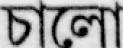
চালো
